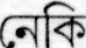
নেকি
